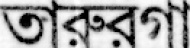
তারুরগা
